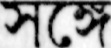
সঙ্গে
